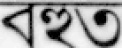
বহুত
